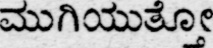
ಮುಗಿಯುತ್ತೋ
